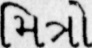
મિત્રો
